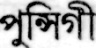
পুন্সিগী
